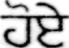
ਹੋਏ
